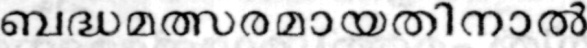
ബദ്ധമത്സരമായതിനാല്‍
